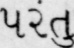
પરંતુ
